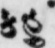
કહું
